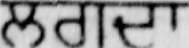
ਲਗਦਾ
